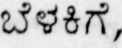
ಬೆಳಕಿಗೆ,
